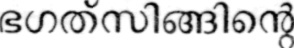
ഭഗത്സിങ്ങിന്റെ
